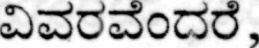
ವಿವರವೆಂದರೆ,
